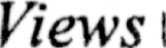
Views।
